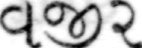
વજીર
